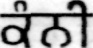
ਕੰਨੀ
